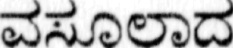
ವಸೂಲಾದ
